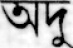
অদু
